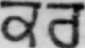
ਕਰ
